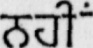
ਨਹੀਂ
